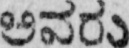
ಅವರು
